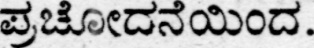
ಪ್ರಚೋದನೆಯಿಂದ.
